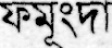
ফমূংদা
